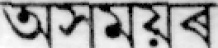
অসময়ৰ
